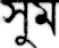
সুম
